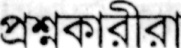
প্রশ্নকারীরা
